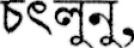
চৎলুনু,
